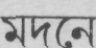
মদনে
